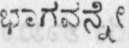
ಭಾಗವನ್ನೇ
